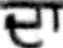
ਦਾ
